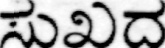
ಸುಖದ
